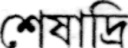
শেষাদ্রি
